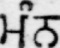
ਮੰਨ
